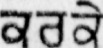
ਕਰਕੇ
